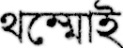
থম্মোই
